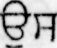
ਉਸ
